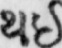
થઈ
